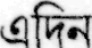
এদিন
